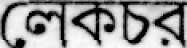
লেকচর
